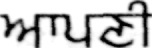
ਆਪਣੀ
